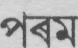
পৰম
